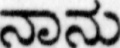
ನಾನು
